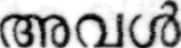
അവള്‍
